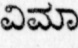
ವಿಮಾ
